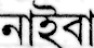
নাইবা
